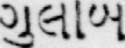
ગુલાબ
